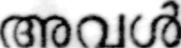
അവള്‍
